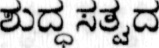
ಶುದ್ಧಸತ್ವದ
